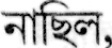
নাছিল,
